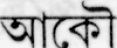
আকৌ
